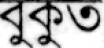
বুকুত
